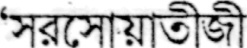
‘সরসোয়াতীজী
